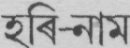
হৰি-নাম
